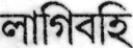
লাগিবহি
